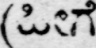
(ಹೀಗೆ
